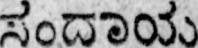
ಸಂದಾಯ
